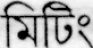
মিটিং
